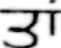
ਤਾਂ
